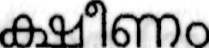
ക്ഷീണം
